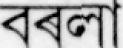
বৰলা
